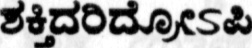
ಶಕ್ತಿದರಿದ್ರೋsಪಿ
